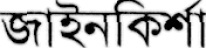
জাইনকির্শা
